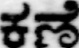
ಕಣೆ
